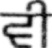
ਵੀ
